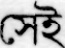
সেই
